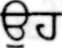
ਉਹ
